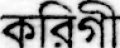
করিগী
